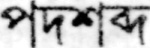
পদশব্দ
